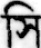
সি
